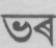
ভৰ
